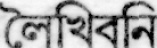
লৈখিবনি
